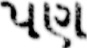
પણ
